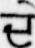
ਦੇ
